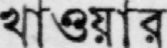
খাওয়ার
